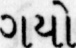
ગયો
